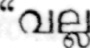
“വല്ല
